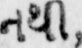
નથી,
